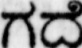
ಗದೆ
